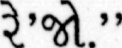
રે'જો."
